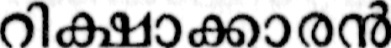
റിക്ഷാക്കാരന്‍
